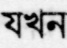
যখন
